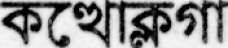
কত্থোক্লগা
